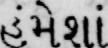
હંમેશાં
